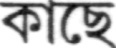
কাছে
